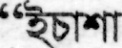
“ইচাশা
